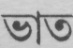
ভাত
